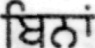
ਬਿਨਾਂ
